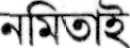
নমিতাই
